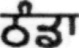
ਠੰਡਾ
